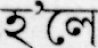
হ'লে
